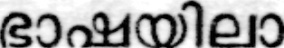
ഭാഷയിലാ
